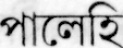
পালেহি
